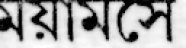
ময়ামদো
